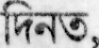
দিনত,
